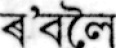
ৰ'বলৈ
